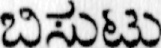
ಬಿಸುಟು
